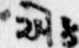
એક
